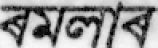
ৰমলাৰ
